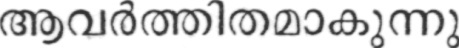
ആവര്‍ത്തിതമാകുന്നു
